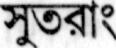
সুতরাং
